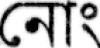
নোং
